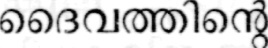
ദൈവത്തിന്റെ
